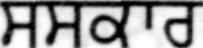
ਸਸਕਾਰ
